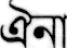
ঐনা
